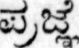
ಪ್ರಜ್ಞೆ
